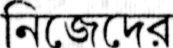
নিজেদের
